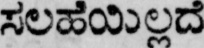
ಸಲಹೆಯಿಲ್ಲದೆ
